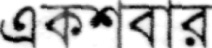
একশবার
